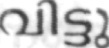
വിട്ടു
